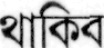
থাকিব
